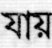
যায়
